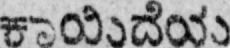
ಕಾಯಿದೆಯ
